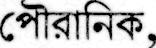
পৌরানিক,
